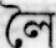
লৈ
